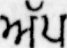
ਅੱਪ
